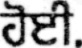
ਹੋਈ,
